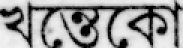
খন্তেকো
